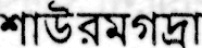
শাউরমগদ্রা
